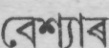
বেশ্যাৰ
